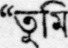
‘‘তুমি
